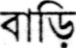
বাড়ি
